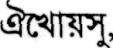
ঐখোয়সু,
